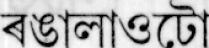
ৰঙালাওটো
